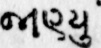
જાણ્યું
